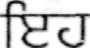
ਇਹ
